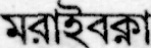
মরাইবক্না
